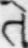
તે
